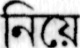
নিয়ে
